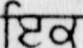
ਇਕ
